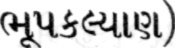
ભૂપકલ્યાણ)
